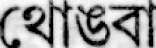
থোঙবা
